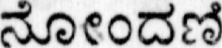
ನೋಂದಣಿ
